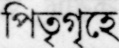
পিতৃগৃহে
